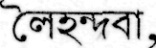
লৈহন্দবা,
